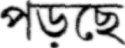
পড়ছে
